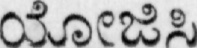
ಯೋಜಿಸಿ
